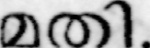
മതി.
